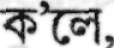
ক'লে,
